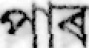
পাৰ
